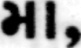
મા,
